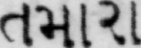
તમારા
